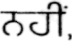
ਨਹੀਂ,
